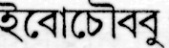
ইবোচৌববু
